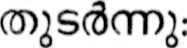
തുടര്‍ന്നു:
